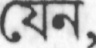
যেন,
